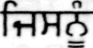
ਜਿਸਨੂੰ
